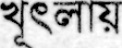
খূৎলায়
